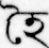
হৈ
